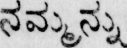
ನಮ್ಮನ್ನು
